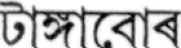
টাঙ্গাবোৰ
